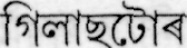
গিলাছটোৰ
